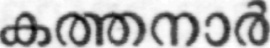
കത്തനാര്‍
